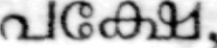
പക്ഷേ,
